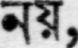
নয়,
